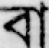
বা
